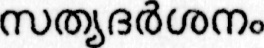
സത്യദര്‍ശനം
